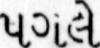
પગલે
